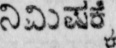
ನಿಮಿಷಕ್ಕೆ
